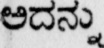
ಅದನ್ನು
